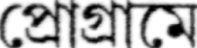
প্রোগ্রামে
